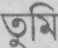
তুমি
